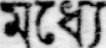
মধ্যে
